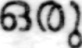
ഒരു
